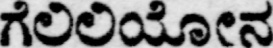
ಗೆಲಿಲಿಯೋನ
